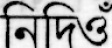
নিদিওঁ
